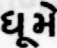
ધૂમે
